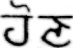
ਹੋਣ
